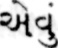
એવું
